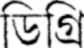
ডিগ্রি
